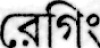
রেগিং
